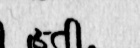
કલકત્તાની
